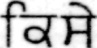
ਕਿਸੇ
